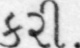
કરી.
